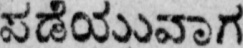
ಪಡೆಯುವಾಗ
